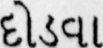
દોડવા
